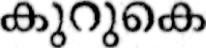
കുറുകെ
